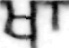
ਖਾ
